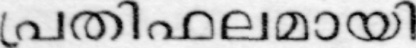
പ്രതിഫലമായി
